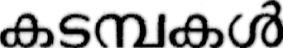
കടമ്പകള്‍
